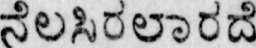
ನೆಲಸಿರಲಾರದೆ
